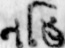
નહિ
